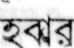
হবার
